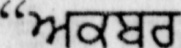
''ਅਕਬਰ
